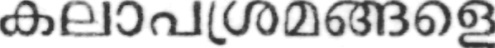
കലാപശ്രമങ്ങളെ
